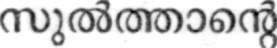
സുല്‍ത്താന്റെ
